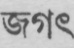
জগৎ
